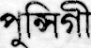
পুন্সিগী
